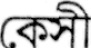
কেসী
